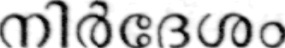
നിര്‍ദേശം
